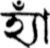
হ্যাঁ
